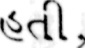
હતી,
